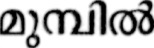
മുമ്പില്‍
